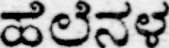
ಹೆಲೆನಳ
